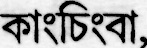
কাংচিংবা,
